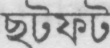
ছটফট
